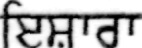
ਇਸ਼ਾਰਾ
